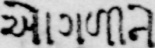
ઓગળીને
